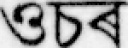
ওচৰ
